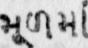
મૂળમાં
